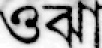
ওঝা
